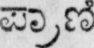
ಪ್ರಾಣಿ
